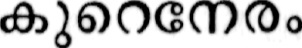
കുറെനേരം
